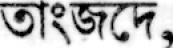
তাংজদে,
